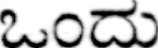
ಒಂದು
